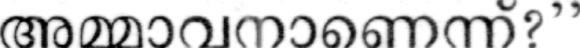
അമ്മാവനാണെന്ന്?"
